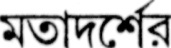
মতাদর্শের
